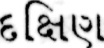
દક્ષિણ
